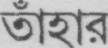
তাঁহার
